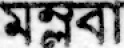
মম্লবা
